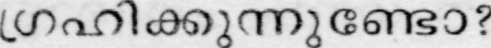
ഗ്രഹിക്കുന്നുണ്ടോ?
